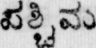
ಪಶ್ಚಿಮ
